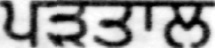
ਪੜਤਾਲ
